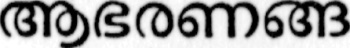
ആഭരണങ്ങ
